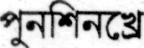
পুনশিনখ্রে
